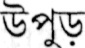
উপুড়
